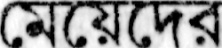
মেয়েদের
